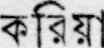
করিয়া
